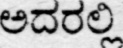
ಅದರಲ್ಲಿ
